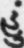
હું
